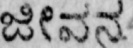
ಜೀವನ
